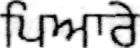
ਪਿਆਰੇ
